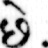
છે.
